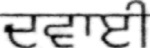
ਦਵਾਈ
